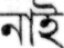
নাই
